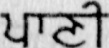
ਪਾਣੀ
